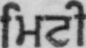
ਮਿਟੀ
